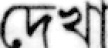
দেখা
